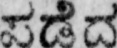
ಪಡೆದ
